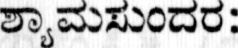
ಶ್ಯಾಮಸುಂದರ:
